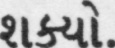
શક્યો.
